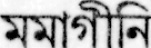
মমাগীনি
